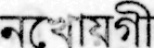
নখোয়গী
